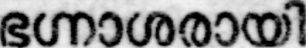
ഭഗ്നാശരായി
